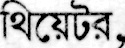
থিয়েটর,
